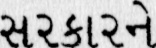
સરકારને
